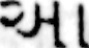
આ
